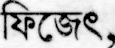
ফিজেৎ,
